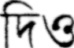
দিও
